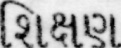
શિક્ષણ
